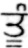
ਤੂੰ
